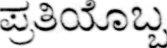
ಪ್ರತಿಯೊಬ್ಬ
